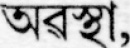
অৱস্থা,
